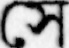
সে
